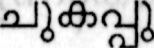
ചുകപ്പു
